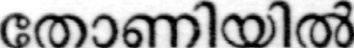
തോണിയില്‍
